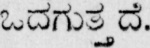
ಒದಗುತ್ತದೆ.
